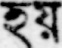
হয়
